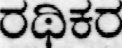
ರಥಿಕರ
